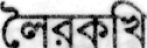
লৈরকখি
